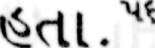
હતા.૫૬
